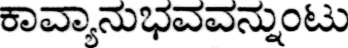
ಕಾವ್ಯಾನುಭವವನ್ನುಂಟು
